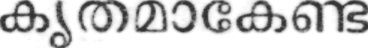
കൃതമാകേണ്ട
